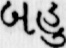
બહુ
